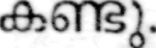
കണ്ടു.
